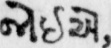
જોઈએ,
